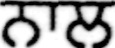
ਨਾਲ
